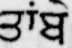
ਤਾਂਬੇ
